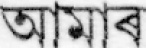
আমাৰ
